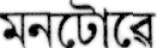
মনটোৱে
